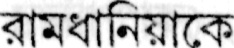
রামধানিয়াকে
